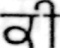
ਕੀ
